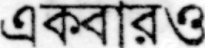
একবারও
